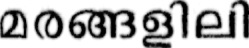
മരങ്ങളിലി
